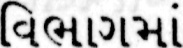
વિભાગમાં
